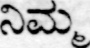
ನಿಮ್ಮ
